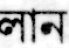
লান
